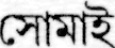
সোমাই
